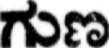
ಗುಣ
